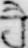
ਹੈ
